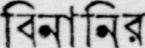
বিনানির
